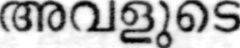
അവളുടെ
